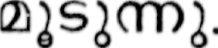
മൂടുന്നു.
